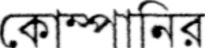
কোম্পানির
